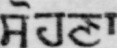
ਸੋਹਣਾ
